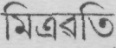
মিত্ৰৱতি
